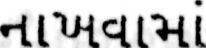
નાખવામાં
